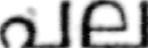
പല
